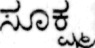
ಸೂಕ್ಷ್ಮ
